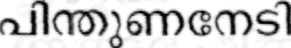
പിന്തുണനേടി
